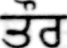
ਤੌਰ
